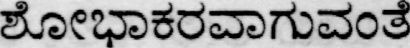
ಶೋಭಾಕರವಾಗುವಂತೆ
